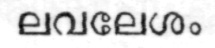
ലവലേശം
